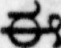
ಈ
